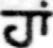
ਹਾਂ
